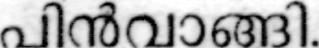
പിന്‍വാങ്ങി.
